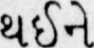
થઈને
